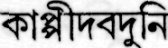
কাপ্পীদবদুনি
